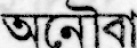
অনৌবা
